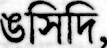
ঙসিদি,
